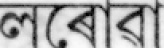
লৰোৱা
